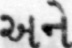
અને
